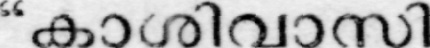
"കാശിവാസി
